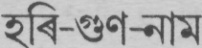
হৰি-গুণ-নাম
